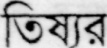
তিষ্যর
